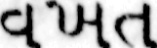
વખત
